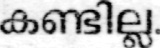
കണ്ടില്ല.
